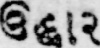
ઉદ્ધાર
